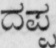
ದಪ್ಪ
